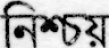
নিশ্চয়
